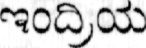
ಇಂದ್ರಿಯ
